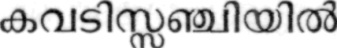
കവടിസ്സഞ്ചിയില്‍
